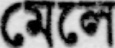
মেলে
